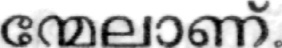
ന്മേലാണ്.
